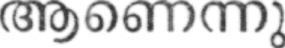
ആണെന്നു
